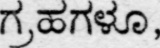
ಗ್ರಹಗಳೂ,
